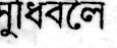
সুধিবলৈ
